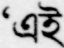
‘এই
